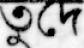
তুদে
